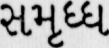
સમૃધ્ધ
